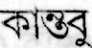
কান্তবু
